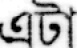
এটা
